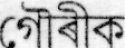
গৌৰীক
